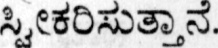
ಸ್ವೀಕರಿಸುತ್ತಾನೆ.
